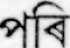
পৰি
